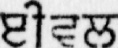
ਈਵਲ
